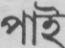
পাই
